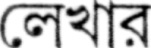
লেখার
